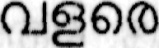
വളരെ
